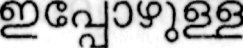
ഇപ്പോഴുള്ള
